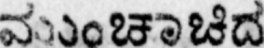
ಮುಂಚಾಚಿದ
